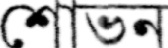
শোভন
